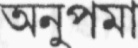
অনুপমা
